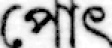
পোৎ
